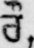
ਰੌ,
